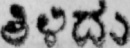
ತಿಳಿದು
